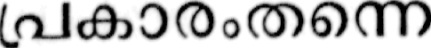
പ്രകാരംതന്നെ
